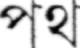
পথ
